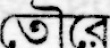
তৌরে
